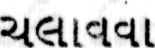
ચલાવવા
